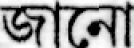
জানো
